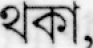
থকা,
